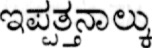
ಇಪ್ಪತ್ತನಾಲ್ಕು
